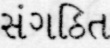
સંગઠિત
